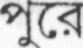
পুরে
